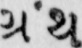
ગ્રંથ
